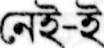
নেই-ই
